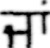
ਜਾਂ
